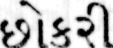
છોકરી
